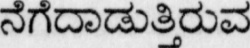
ನೆಗೆದಾಡುತ್ತಿರುವ
